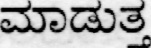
ಮಾಡುತ್ತ
